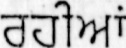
ਰਹੀਆਂ
